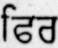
ਫਿਰ
